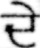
ਦੇ
